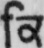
ਕਿ
